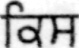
ਕਿਸ
